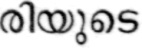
രിയുടെ
